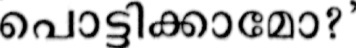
പൊട്ടിക്കാമോ?’
